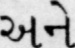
અને
